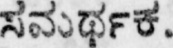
ಸಮರ್ಥಕ.
